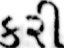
કરી
